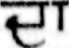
ਦਾ
